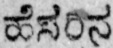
ಹೆಸರಿನ
